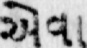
એવા
